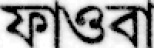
ফাওবা
